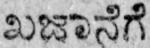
ಖಜಾನೆಗೆ
